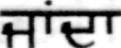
ਜਾਂਦਾ
